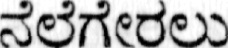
ನೆಲೆಗೇರಲು
